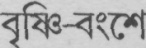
বৃষ্ণি-বংশে
